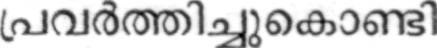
പ്രവര്‍ത്തിച്ചുകൊണ്ടി
